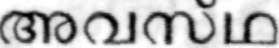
അവസ്ഥ
